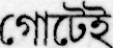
গোটেই
